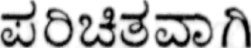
ಪರಿಚಿತವಾಗಿ
